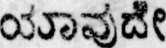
ಯಾವುದೇ
